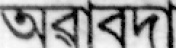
অৱাবদা
